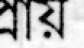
প্রায়
